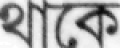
থাকে
